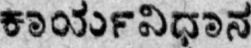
ಕಾರ್ಯವಿಧಾನ
